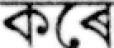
কৰে
